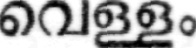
വെള്ളം
